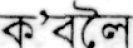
ক'বলৈ
